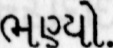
ભણ્યો.
